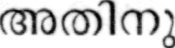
അതിനു
